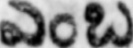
ಎಂಬ
